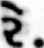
રે.
